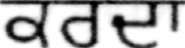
ਕਰਦਾ
